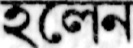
হলেন
